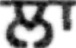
ਲਾ
